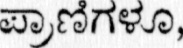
ಪ್ರಾಣಿಗಳೂ,
